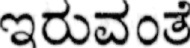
ಇರುವಂತೆ
